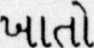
ખાતો
